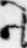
ને
